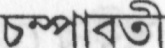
চম্পাবতী
